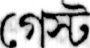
গেস্ট
